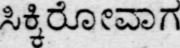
ಸಿಕ್ಕಿರೋವಾಗ
